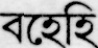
বহেহি
